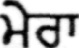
ਮੇਰਾ
